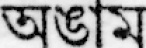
অঙাম
